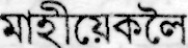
মাহীয়েকলৈ
